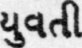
યુવતી
